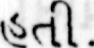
હતી.
